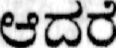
ಆದರೆ
